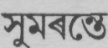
সুমৰন্তে
